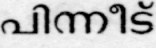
പിന്നീട്
